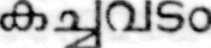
കച്ചവടം
